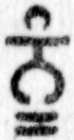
ਨੂੰ
